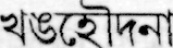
খঙহৌদনা
